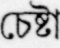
চেষ্টা
